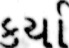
કર્યા
